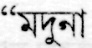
“মদুনা
